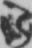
છે
